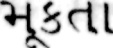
મૂકતા
